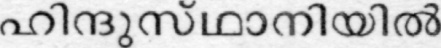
ഹിന്ദുസ്ഥാനിയില്‍
